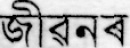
জীৱনৰ
